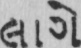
લાગે
